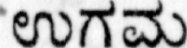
‘ಉಗಮ
